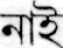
নাই
